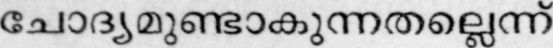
ചോദ്യമുണ്ടാകുന്നതല്ലെന്ന്
